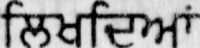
ਲਿਖਦਿਆਂ
